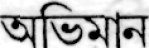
অভিমান
